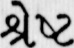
શ્રેષ્ટ
